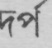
দৰ্প
